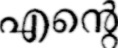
എന്റെ
